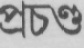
প্ৰচণ্ড
